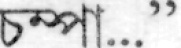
চম্পা..."
